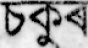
চকুৰ
